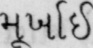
મૂર્ખાઈ
